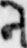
ને
